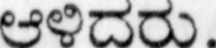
ಆಳಿದರು.
